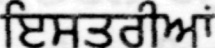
ਇਸਤਰੀਆਂ
